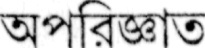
অপরিজ্ঞাত
